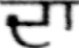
ਦਾ
